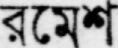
রমেশ
